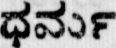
ಧರ್ಮ
